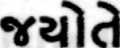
જ્યોતે
